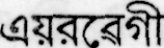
এয়রৱেগী
